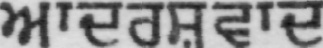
ਆਦਰਸ਼ਵਾਦ
